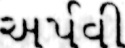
અર્પવી
